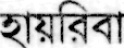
হায়রিবা
